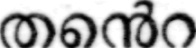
തന്റെ
